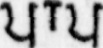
ਪਾਪ
